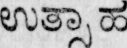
ಉತ್ಸಾಹ
